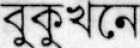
বুকুখনে
